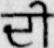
ਦੀ
